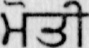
ਮੋਤੀ
